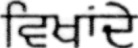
ਵਿਖਾਂਦੇ
